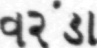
વરંડા
